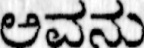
ಅವನು
